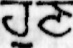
ਹੁਣ
